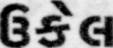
ઉકેલ
